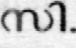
സി.
